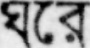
ঘরে
